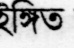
ইঙ্গিত
